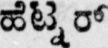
ಹೆಟ್ನರ್
